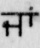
ਜਾਂ
